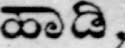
ಹಾಡಿ,
